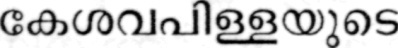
കേശവപിള്ളയുടെ
